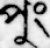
পুং
